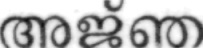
അജ്ഞ
